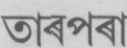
তাৰপৰা
